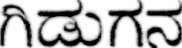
ಗಿಡುಗನ
